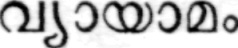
വ്യായാമം
